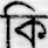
কি
